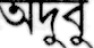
অদুবু
